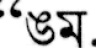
“ঙম
